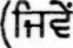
(ਜਿਵੇਂ
